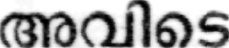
അവിടെ
